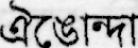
ঐঙোন্দা
